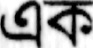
এক
